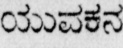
ಯುವಕನ
